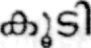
കൂടി
